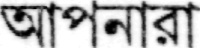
আপনারা
